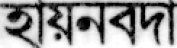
হায়নবদা
